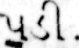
પડી.
